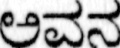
ಅವನ
